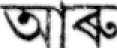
আৰু
